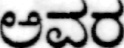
ಅವರ
